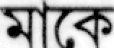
মাকে
